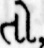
તો,
